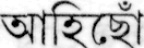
আহিছোঁ
